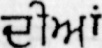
ਦੀਆਂ
